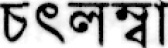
চৎলম্বা
